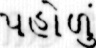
પહોળું
